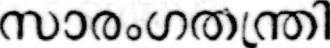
സാരംഗതന്ത്രി
